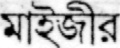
মাইজীর
